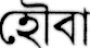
হৌবা
